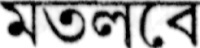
মতলবে
